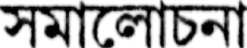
সমালোচনা
